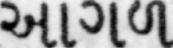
આગળ
